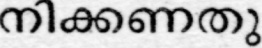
നിക്കണതു
